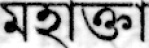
মহাক্তা
